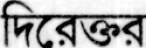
দিরেক্তর
